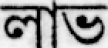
লাভ
